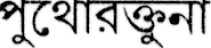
পুথোরক্তুনা
